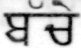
ਬੱਚੇ
